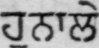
ਹੁਨਾਲੇ
